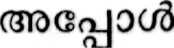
അപ്പോള്‍
